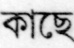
কাছে
